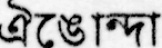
ঐঙোন্দা
